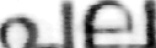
പല
